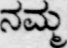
ನಮ್ಮ
